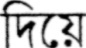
দিয়ে
